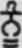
ਨੂੰ
